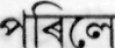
পৰিলে
